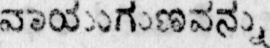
ವಾಯುಗುಣವನ್ನು
